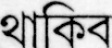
থাকিব
